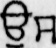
ਉਸ
